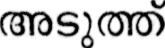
അടുത്ത്
